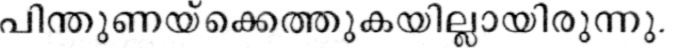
പിന്തുണയ്ക്കെത്തുകയില്ലായിരുന്നു.
